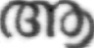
ആ
